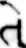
તે
